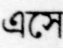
এসে
